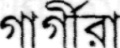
গার্গীরা
